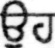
ਉਹ
